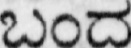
ಬಂದ
